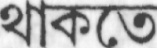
থাকতে
